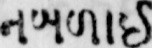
નબળાઈ
